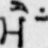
ਮੈਂ
